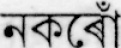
নকৰোঁ
